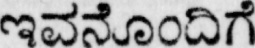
ಇವನೊಂದಿಗೆ
